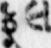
ફૂલ
